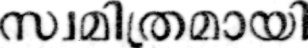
സ്വമിത്രമായി
